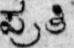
ಪ್ರತಿ
